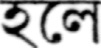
হলে
